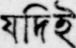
যদিই
